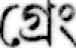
গ্রেং
